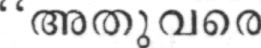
"അതുവരെ
